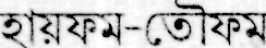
হায়ফম-তৌফম
